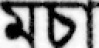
মচা
